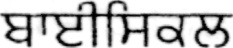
ਬਾਈਸਿਕਲ
